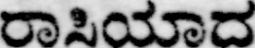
ರಾಸಿಯಾದ
